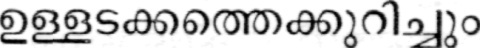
ഉള്ളടക്കത്തെക്കുറിച്ചും
